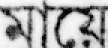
মায়ে
